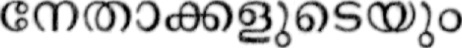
നേതാക്കളുടെയും
